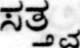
ಸತ್ತ್ವ
